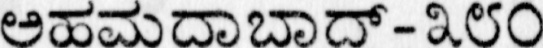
ಅಹಮದಾಬಾದ್-೩೮೦
